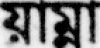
য়াম্না
